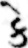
કે
